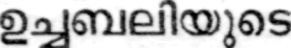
ഉച്ചബലിയുടെ
